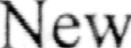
New
